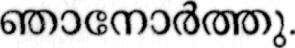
ഞാനോര്‍ത്തു.
